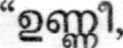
“ഉണ്ണീ,
